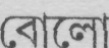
বোলো
